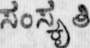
ಸಂಸ್ಕೃತಿ
